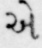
એ
